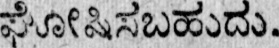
ಘೋಷಿಸಬಹುದು.
